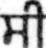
ਸੀ
